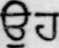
ਉਹ
